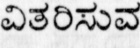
ವಿತರಿಸುವ
